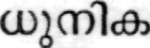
ധുനിക
